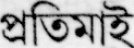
প্রতিমাই
